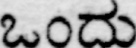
ಒಂದು
